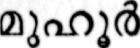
മുഹൂര്‍
